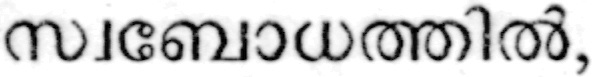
സ്വബോധത്തില്‍,
